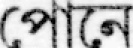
পোনে
